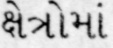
ક્ષેત્રોમાં
